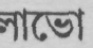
লাভো
